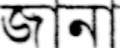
জানা
